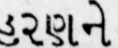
હરણને
